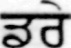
ਡਰੇ
